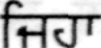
ਜਿਹਾ
